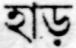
হাড়
